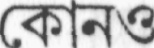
কোনও
